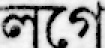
লগে
